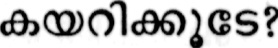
കയറിക്കൂടേ?
